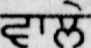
ਵਾਲੇ
